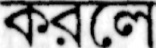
করলে
